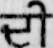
ਦੀ
